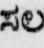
ಸಲ
